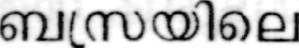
ബസ്രയിലെ
